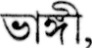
ভাঙ্গী,
